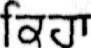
ਕਿਹਾ
